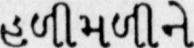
હળીમળીને
